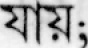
যায়;
